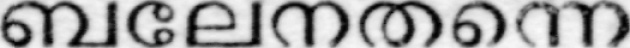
ബലേനതന്നെ
